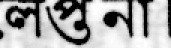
লেপ্তনা
